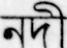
নদী
